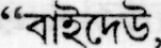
"বাইদেউ,
